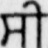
ਸੀ
